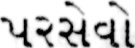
પરસેવો
